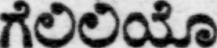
ಗೆಲಿಲಿಯೊ
